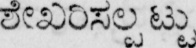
ಶೇಖರಿಸಲ್ಪಟ್ಟು
